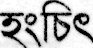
হংচিৎ
